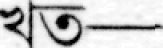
খত-
